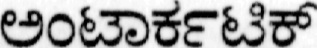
ಅಂಟಾರ್ಕಟಿಕ್
